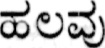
ಹಲವು
